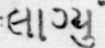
લાગ્યું
